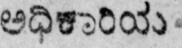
ಅಧಿಕಾರಿಯ
